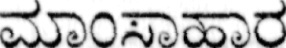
ಮಾಂಸಾಹಾರ
